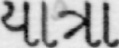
યાત્રા
